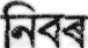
নিবৰ
